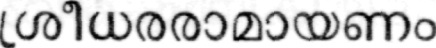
ശ്രീധരരാമായണം
